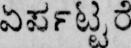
ಏರ್ಪಟ್ಟರೆ
